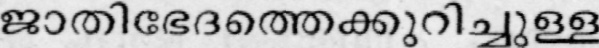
ജാതിഭേദത്തെക്കുറിച്ചുള്ള
